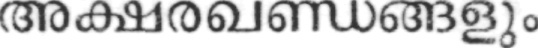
അക്ഷരഖണ്ഡങ്ങളും
